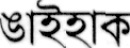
ঙাইহাক
